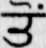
ਤੋਂ
